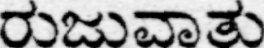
ರುಜುವಾತು
